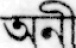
অনী
